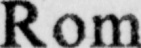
Rom
